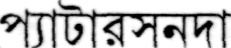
প্যাটারসনদা
